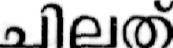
ചിലത്
